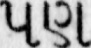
પણ
